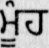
ਮੂੰਹ
